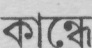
কান্ধে
